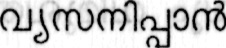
വ്യസനിപ്പാന്‍
